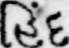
હિંદ
